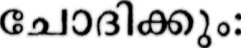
ചോദിക്കും:
